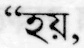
"হয়,
